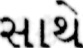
સાથે
